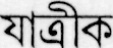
যাত্রীক
